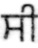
ਸੀ
